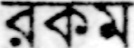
রকম
